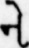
ને
